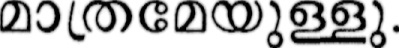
മാത്രമേയുള്ളു.
